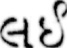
લઈ
